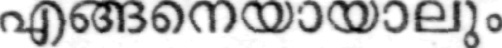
എങ്ങനെയായാലും
